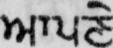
ਆਪਣੇ
